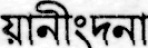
য়ানীংদনা
